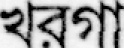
খরগা
